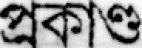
প্রকাণ্ড
